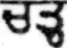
ਚੜ੍ਹ
